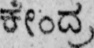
ಕೇಂದ್ರ
